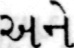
અને
